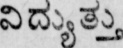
ವಿದ್ಯುತ್ತು
